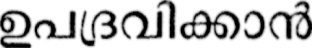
ഉപദ്രവിക്കാന്‍
